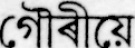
গৌৰীয়ে
